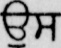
ਉਸ
